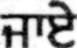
ਜਾਏ
